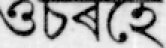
ওচৰহে
